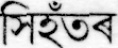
সিহঁতৰ
